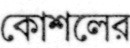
কোশলের
